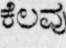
ಕೆಲವು
